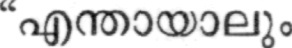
“എന്തായാലും
